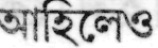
আহিলেও
